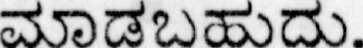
ಮಾಡಬಹುದು.
